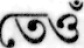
তেওঁ
